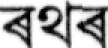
ৰথৰ
